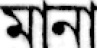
মানা
